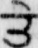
ਤੇ
